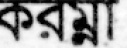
করম্না
